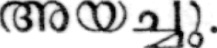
അയച്ചു.
